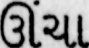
ઊંચા
